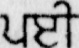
ਪਈ
